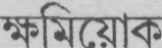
ক্ষমিয়োক
